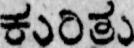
ಕುರಿತು
